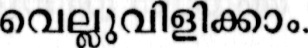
വെല്ലുവിളിക്കാം.
